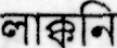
লাক্কনি
